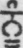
ਨੂੰ
